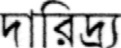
দারিদ্র্য
